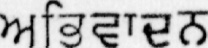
ਅਭਿਵਾਦਨ
